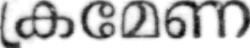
ക്രമേണ
